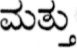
ಮತ್ತು
